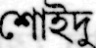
শোইদু
